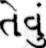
તેવું
